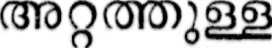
അറ്റത്തുള്ള
